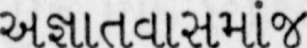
અજ્ઞાતવાસમાંજ
